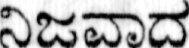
ನಿಜವಾದ
